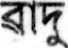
ৱাদু
